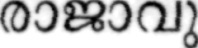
രാജാവു
